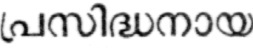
പ്രസിദ്ധനായ
